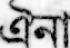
ঐনা
